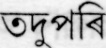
তদুপৰি
